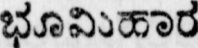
ಭೂಮಿಹಾರ
